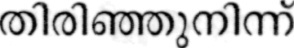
തിരിഞ്ഞുനിന്ന്
